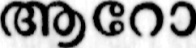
ആറോ
